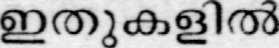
ഇതുകളില്‍
